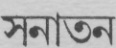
সনাতন
